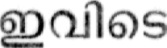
ഇവിടെ
